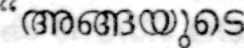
“അങ്ങയുടെ
